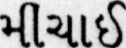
મીંચાઈ
